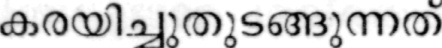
കരയിച്ചുതുടങ്ങുന്നത്
